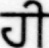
ਹੀ
